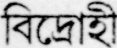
বিদ্রোহী
